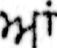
ਆਂ
